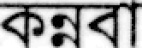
কন্নবা
